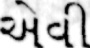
એવી
